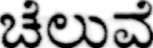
ಚೆಲುವೆ
